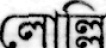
লোল্লি
